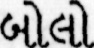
બોલો
